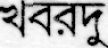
খবরদু
